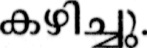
കഴിച്ചു.
